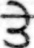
ਤੇ
